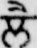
ਲੈ
